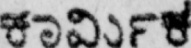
ಕಾರ್ಮಿಕ
